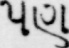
પણ
